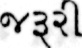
જરૂરી
